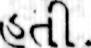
હતી.
